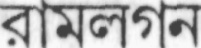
রামলগন
